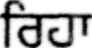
ਰਿਹਾ
